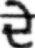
ਦੇ
